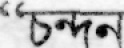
"চন্দন
